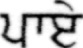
ਪਾਏ
